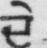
ਦੇ
